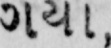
ગયા,
